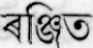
ৰঞ্জিত
